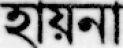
হায়না
